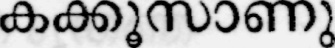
കക്കൂസാണു
